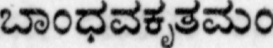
ಬಾಂಧವಕೃತಮಂ
